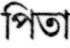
পিতা
